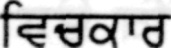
ਵਿਚਕਾਰ
